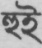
হুই
